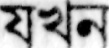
যখন
